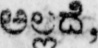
ಅಲ್ಲದೆ,
